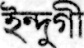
ইন্দুগী
